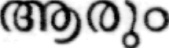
ആരും
